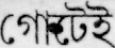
গোটেই
